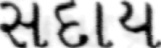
સદાય
